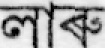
লাৰু
